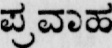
ಪ್ರವಾಹ
